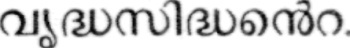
വൃദ്ധസിദ്ധന്റെ.
